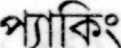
প্যাকিং
